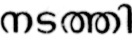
നടത്തി
